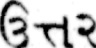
ઉત્તર
